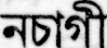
নচাগী
